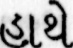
હાથે
